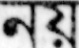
নয়
